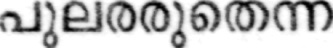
പുലരരുതെന്ന
